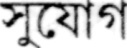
সুযোগ
